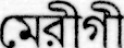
মেরীগী
